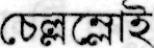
চেল্লম্লোই
